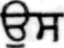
ਉਸ
